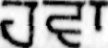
ਹਵਾ
